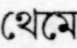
থেমে
